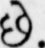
છે.
